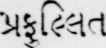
પ્રફુલ્લિત
